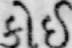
કોઈ
